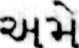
અમે
